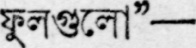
ফুলগুলো’’—
